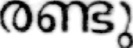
രണ്ടു
